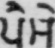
ਪੈਸੇ
